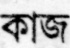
কাজ
